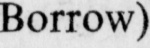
Borrow)
